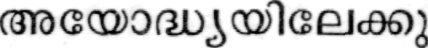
അയോദ്ധ്യയിലേക്കു
